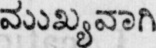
ಮುಖ್ಯವಾಗಿ
